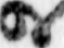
જ
